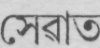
সেৱাত
